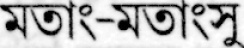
মতাং-মতাংসু
